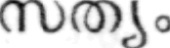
സത്യം
